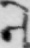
ને
